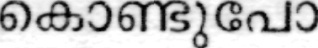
കൊണ്ടുപോ
